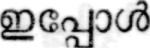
ഇപ്പോള്‍
